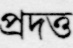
প্রদত্ত
